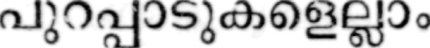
പുറപ്പാടുകളെല്ലാം
